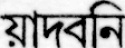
য়াদবনি
